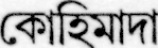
কোহিমাদা
